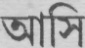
আসি
